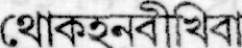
থোকহনবীখিবা
